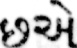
છએ
